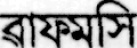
ৱাফমসি
